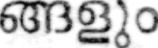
ങ്ങളും
